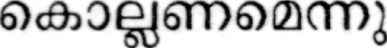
കൊല്ലണമെന്നു
